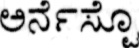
ಅರ್ನೆಸ್ಟೊ
